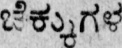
ಚೆಕ್ಕುಗಳ
